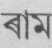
ৰাম
